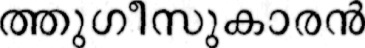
ത്തുഗീസുകാരന്‍
